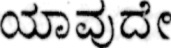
ಯಾವುದೇ
